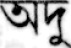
অদু
